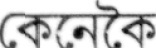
কেনেকৈ
